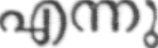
എന്നു
